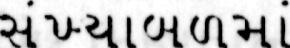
સંખ્યાબળમાં
